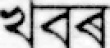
খবৰ
